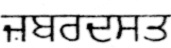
ਜ਼ਬਰਦਸਤ
